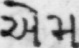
એમ
